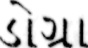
ડોગ્રા
